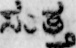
ಸುತ್ತ
